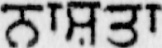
ਨਾਸ਼ਤਾ
